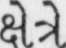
ક્ષેત્રે
